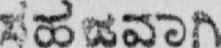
ಸಹಜವಾಗಿ
